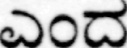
ಎಂದ
